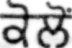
ਕੋਲੋਂ
